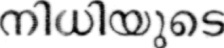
നിധിയുടെ
